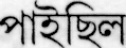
পাইছিল
